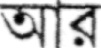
আর
